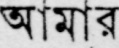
আমার
